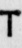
T
